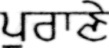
ਪੁਰਾਣੇ
